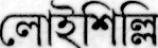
লোইশিল্লি
